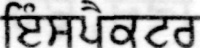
ਇੰਸਪੈਕਟਰ
